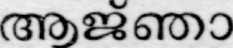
ആജ്ഞാ
